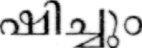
ഷിച്ചും
